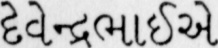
દેવેન્દ્રભાઈએ
